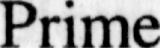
Prime
